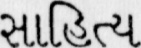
સાહિત્ય
